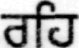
ਰਹਿ
